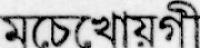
মচেখোয়গী
